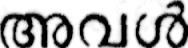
അവള്‍
